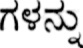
ಗಳನ್ನು
